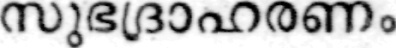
സുഭദ്രാഹരണം
